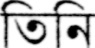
তিনি
